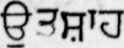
ਉਤਸ਼ਾਹ
